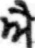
ਐ
